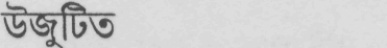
উজুটিত
